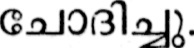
ചോദിച്ചു.
